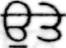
ਉਤੇ
